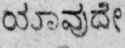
ಯಾವುದೇ
